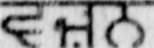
ਵਜ਼ਨ
